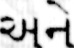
અને
